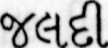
જલદી
